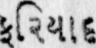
ફરિયાદ
